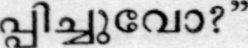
ച്ചിച്ചുവോ?”
